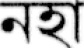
নহা
